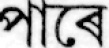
পাৰে
